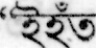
"ইহঁত
